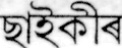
ছাইকীৰ
